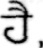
ਹੈ,
